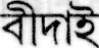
বীদাই
